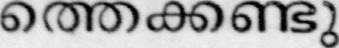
ത്തെക്കണ്ടു
